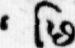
'છિ
